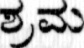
ಶ್ರಮ
